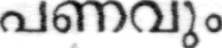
പണവും
